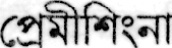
প্রেমীশিংনা
